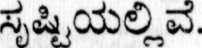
ಸೃಷ್ಟಿಯಲ್ಲಿವೆ.
